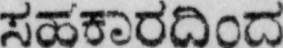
ಸಹಕಾರದಿಂದ
